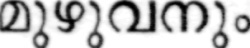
മുഴുവനും
